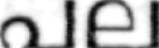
പല
